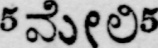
5ಮೇಲಿ5
